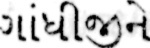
ગાંધીજીને
